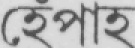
হেঁপাহ
